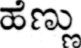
ಹೆಣ್ಣು
